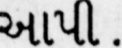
આપી.
